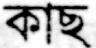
কাছ
